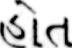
હોત
